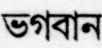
ভগবান
